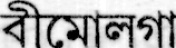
বীমোলগা
